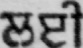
ਲਈ
